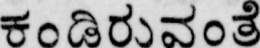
ಕಂಡಿರುವಂತೆ
